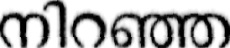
നിറഞ്ഞ
